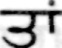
ਤਾਂ
